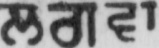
ਲਗਵਾ
